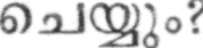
ചെയ്യും?
